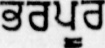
ਭਰਪੂਰ
